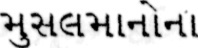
મુસલમાનોના
